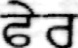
ਫੇਰ
